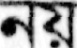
নয়
